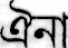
ঐনা
